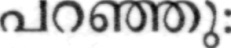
പറഞ്ഞു:
